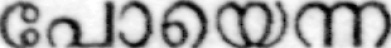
പോയെന്ന
